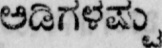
ಅಡಿಗಳಷ್ಟು
